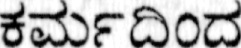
ಕರ್ಮದಿಂದ
